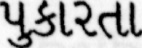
પુકારતા
